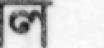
ল
